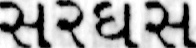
સરઘસ
